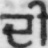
ਦੀ
